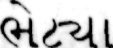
ભેટયા
